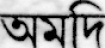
অমদি
